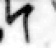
দে
